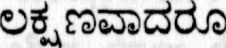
ಲಕ್ಷಣವಾದರೂ
